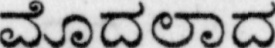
ಮೊದಲಾದ
